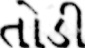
તોડી
